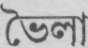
ভৈলা
